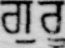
ਗੁਰੂ
